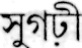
সুগঢ়ী
